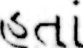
હતાં
